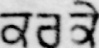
ਕਰਕੇ
